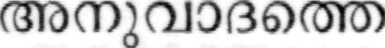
അനുവാദത്തെ
